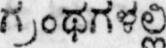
ಗ್ರಂಥಗಳಲ್ಲಿ
